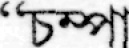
"চম্পা
